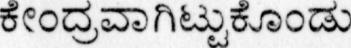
ಕೇಂದ್ರವಾಗಿಟ್ಟುಕೊಂಡು
